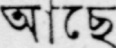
আছে
